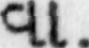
વા.
